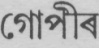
গোপীৰ
